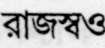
রাজস্বও
